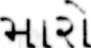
મારો
